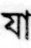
যা
